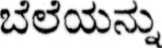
ಬೆಲೆಯನ್ನು
